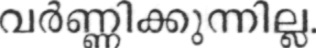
വര്‍ണ്ണിക്കുന്നില്ല.
